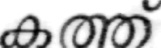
കത്ത്
